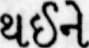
થઈને
